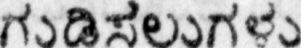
ಗುಡಿಸಲುಗಳು
